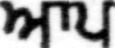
ਆਪ
